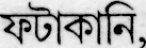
ফটাকানি,
